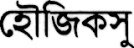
হৌজিকসু
